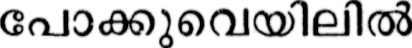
പോക്കുവെയിലില്‍
